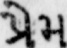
પ્રેમ
